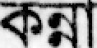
কন্না
